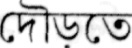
দৌড়তে
